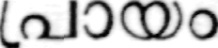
പ്രായം
